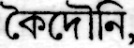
কৈদৌনি,
